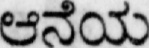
ಆನೆಯ
